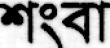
শংবা
